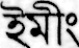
ইমীং
